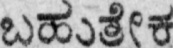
ಬಹುತೇಕ
